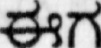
ಈಗ
